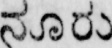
ನೂರು
